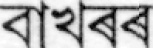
বাখৰৰ
